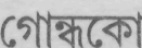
গোন্ধকো
